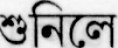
শুনিলে
